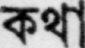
কথা
